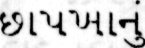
છાપખાનું
